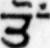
ਤੋਂ
